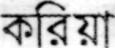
করিয়া
